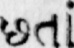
છતાં
